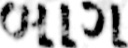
બાગ
